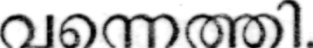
വന്നെത്തി.
